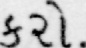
કરો.
